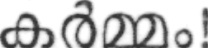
കര്‍മ്മം!
